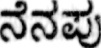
ನೆನಪು
